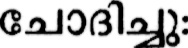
ചോദിച്ചു:
